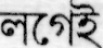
লগেই
